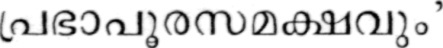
പ്രഭാപൂരസമക്ഷവും'
